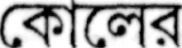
কোলের
